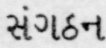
સંગઠન
